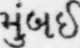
મુંબઈ
